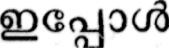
ഇപ്പോള്‍
